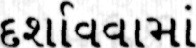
દર્શાવવામાં
